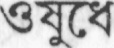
ওষুধে
